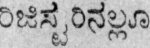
ರಿಜಿಸ್ಟರಿನಲ್ಲೂ
